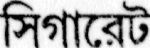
সিগারেট
